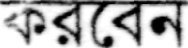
করবেন
